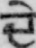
ਦੇ
